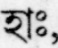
হাঃ,
